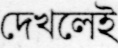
দেখলেই
